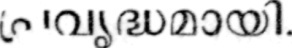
പ്രവൃദ്ധമായി.
